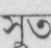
সুত
